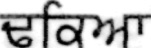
ਢਕਿਆ
